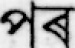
পৰ
